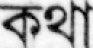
কথা
